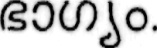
ഭാഗ്യം.
